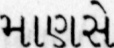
માણસે
